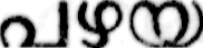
പഴയ
